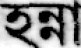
হন্না
